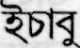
ইচাবু
